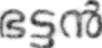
ഭട്ടന്‍
